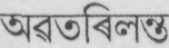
অৱতৰিলন্ত
